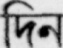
দিন
